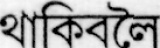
থাকিবলৈ
